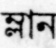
ম্লান
